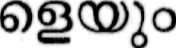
ളെയും
